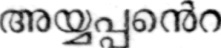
അയ്യപ്പന്റെ
